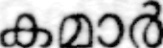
കമാര്‍
